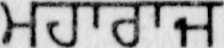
ਮਹਾਰਾਜ
